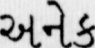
અનેક
